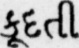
કૂદતી
